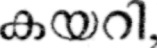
കയറി,
